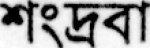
শংদ্রবা
